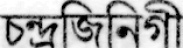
চন্দ্রজিনিগী
